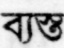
ব্যস্ত
